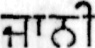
ਜਾਨੀ
